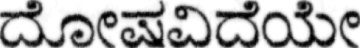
ದೋಷವಿದೆಯೇ
